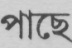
পাছে
